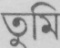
তুমি
